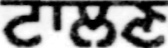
ਟਾਲਣ
